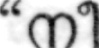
“നീ
